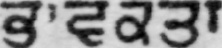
ਭਾਵਕਤਾ
